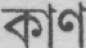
কাণ
